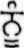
ਨੂੰ
